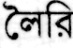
লৈরি
